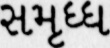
સમૃધ્ધ
